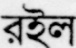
রইল
